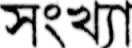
সংখ্যা
